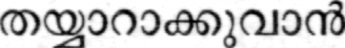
തയ്യാറാക്കുവാന്‍
